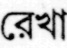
রেখা
